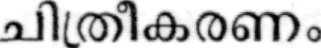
ചിത്രീകരണം
